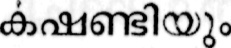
കഷണ്ടിയും
